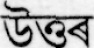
উত্তৰ
